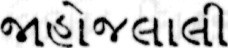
જાહોજલાલી
